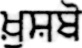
ਖ਼ੁਸ਼ਬੋ
